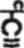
ਨੂੰ
